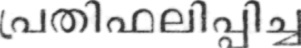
പ്രതിഫലിപ്പിച്ച
